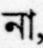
না,
